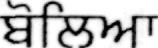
ਬੋਲਿਆ
